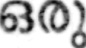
ഒരു
